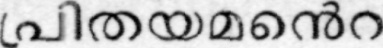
പ്രിതയമന്റെ
